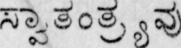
ಸ್ವಾತಂತ್ರ್ಯವು
